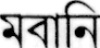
মবানি
